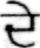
ਦੇ
